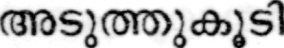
അടുത്തുകൂടി
